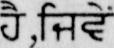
ਹੈ,ਜਿਵੇਂ
